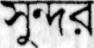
সুন্দর
